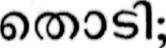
തൊടി;
